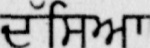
ਦੱਸਿਆ
